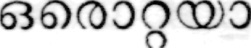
ഒരൊറ്റയാ
